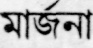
মার্জনা
